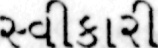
સ્વીકારી
